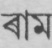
ৰাম
